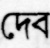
দেব
